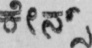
ಕೇನ್ಸ್
